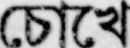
চোখে
